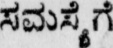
ಸಮಸ್ಯೆಗೆ
